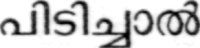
പിടിച്ചാല്‍
